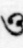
ও
